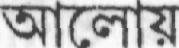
আলোয়
